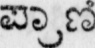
ಪ್ರಾಣಿ
